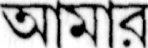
আমার
